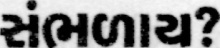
સંભળાય
